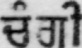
ਚੰਗੀ
